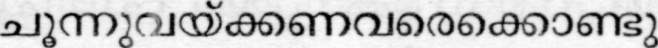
ചൂന്നുവയ്ക്കണവരെക്കൊണ്ടു
